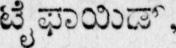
ಟೈಫಾಯಿಡ್,
